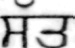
ਸੱਤ
